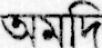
অমদি
